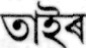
তাইৰ
